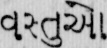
વસ્તુઓ
